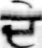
ਦੇ
